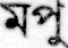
মপু
